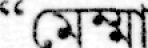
“মেম্মা
